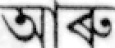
আৰু
